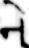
ને
